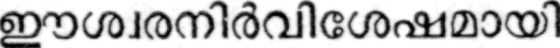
ഈശ്വരനിര്‍വിശേഷമായി
